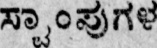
ಸ್ಟಾಂಪುಗಳ
